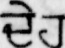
ਦੇਹ
